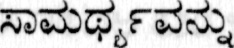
ಸಾಮರ್ಥ್ಯವನ್ನು
